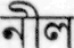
নীল
